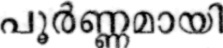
പൂര്‍ണ്ണമായി
